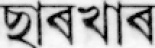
ছাৰখাৰ
